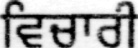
ਵਿਚਾਰੀ
